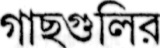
গাছগুলির
